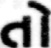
તો
